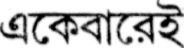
একেবারেই
